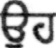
ਉਹ
